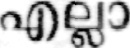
എല്ലാ
